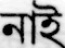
নাই
